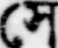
সে
